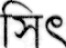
সিৎ
